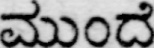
ಮುಂದೆ
